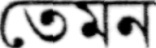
তেমন
